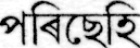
পৰিছেহি
